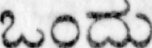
ಒಂದು
